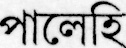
পালেহি
